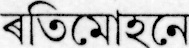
ৰতিমোহনে
